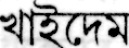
খাইদেম
